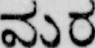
ಮರ
